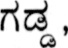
ಗಡ್ಡ,
